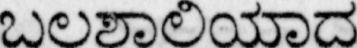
ಬಲಶಾಲಿಯಾದ
